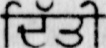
ਦਿੱਤੀ
